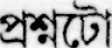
প্রশ্নটো
